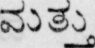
ಮತ್ತು
